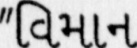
"વિમન
